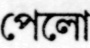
পেলো
